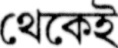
থেকেই
